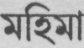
মহিমা
